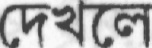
দেখলে
